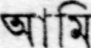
আমি
